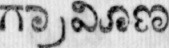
ಗ್ರಾಮೀಣ
